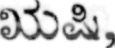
ಋಷಿ,
